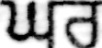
ਘਰ
